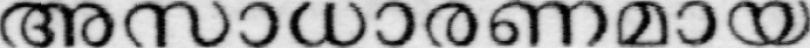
അസാധാരണമായ
